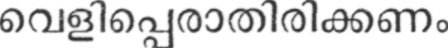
വെളിപ്പെരാതിരിക്കണം
